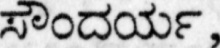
ಸೌಂದರ್ಯ,
